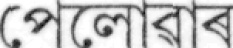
পেলোৱাৰ
